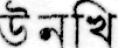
উনখি
